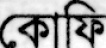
কোফি
